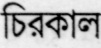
চিরকাল
